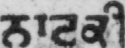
ਨਾਟਕੀ
